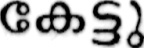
കേട്ടു
